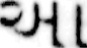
આ
